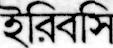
ইরিবসি
